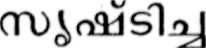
സൃഷ്ടിച്ച
